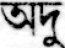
অদু
